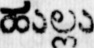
ಹುಲ್ಲು
